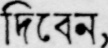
দিবেন,
